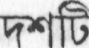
দশটি
